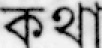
কথা
